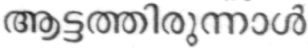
ആട്ടത്തിരുന്നാള്‍
